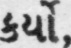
કર્યો,
